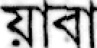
য়াবা
